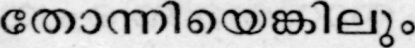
തോന്നിയെങ്കിലും
